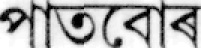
পাতবোৰ
